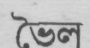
ভৈল
